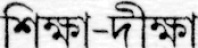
শিক্ষা-দীক্ষা
